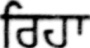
ਰਿਹਾ
